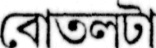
বোতলটা
